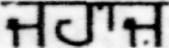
ਜਹਾਜ਼
